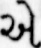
એ
